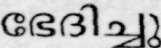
ഭേദിച്ചു
